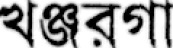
খঞ্জরগা
